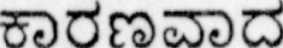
ಕಾರಣವಾದ
